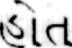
હોત
